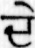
ਦੇ
